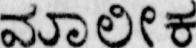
ಮಾಲೀಕ
